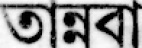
তান্নবা
